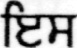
ਇਸ
